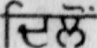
ਦਿਲੋਂ
